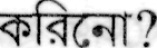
করিনো?
